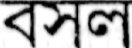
বসল
